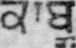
ਕਾਬੂ
